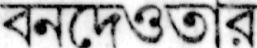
বনদেওতার
